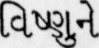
વિષ્ણુને
